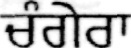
ਚੰਗੇਰਾ
